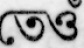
তেওঁ
